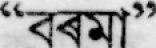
"বৰমা"
